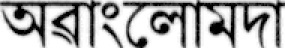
অৱাংলোমদা
